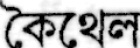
কৈথেল
